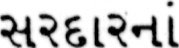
સરદારનાં
